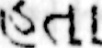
હતા
